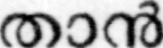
താന്‍
